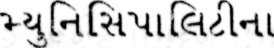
મ્યુનિસિપાલિટીના
